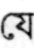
যে
